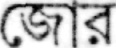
জোর
